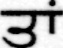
ਤਾਂ
